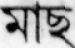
মাছ
